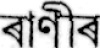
ৰাণীৰ
